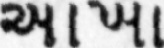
આખા
